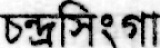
চন্দ্রসিংগা
